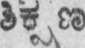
ಶಿಕ್ಷಣ
